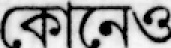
কোনেও
